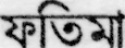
ফতিমা
